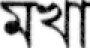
মখা
